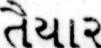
તૈયાર
